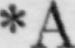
*A
